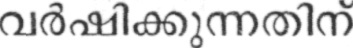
വര്‍ഷിക്കുന്നതിന്
